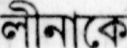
লীনাকে
